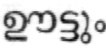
ഊട്ടും
